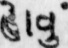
હોવું
